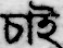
চাই
